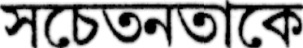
সচেতনতাকে
